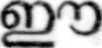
ഈ
